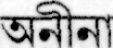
অনীনা
